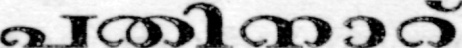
പതിനാറ്
